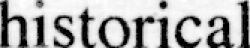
historical
